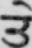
ਤੇ
